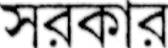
সরকার
